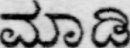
ಮಾಡಿ
